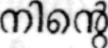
നിന്റെ
